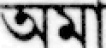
অমা
